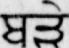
ਬੜੇ
